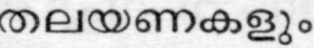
തലയണകളും
